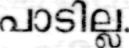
പാടില്ല.
